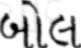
બોલ
